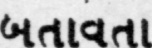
બતાવતા
